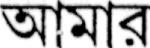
আমার
